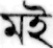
মই
